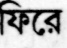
ফিরে
